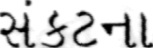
સંકટ
